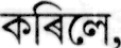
কৰিলে,
